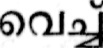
വെച്ച്
